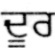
ਦੂਰ
